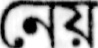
নেয়
